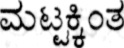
ಮಟ್ಟಕ್ಕಿಂತ
